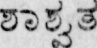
ಶಾಶ್ವತ
